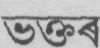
ভক্তৰ
